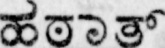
ಹಠಾತ್
